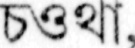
চওথা,
